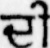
ਦੀ
